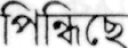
পিন্ধিছে
